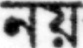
নয়
